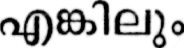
എങ്കിലും
